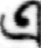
এ
